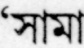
‘সামা
